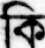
কি
